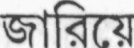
জারিয়ে
